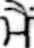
ਮੈਂ
